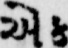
એક
